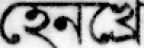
হেনখ্রে
